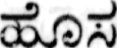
ಹೊಸ
